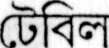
টেবিল
